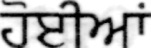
ਹੋਈਆਂ
